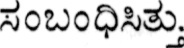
ಸಂಬಂಧಿಸಿತ್ತು.
